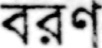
বরণ
